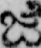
ಜೆ
